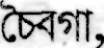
চৈবগা,
